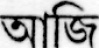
আজি
